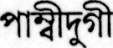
পাম্বীদুগী
